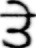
ਤੇ
